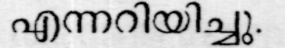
എന്നറിയിച്ചു.
